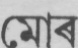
মোৰ
